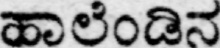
ಹಾಲೆಂಡಿನ
